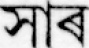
সাৰ
